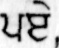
ਪਏ,
